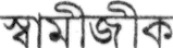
স্বামীজীক
